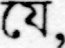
যে,
